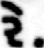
રે.
